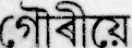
গৌৰীয়ে
